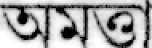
অমত্তা
